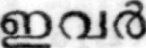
ഇവര്‍
